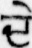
ਦੇ
